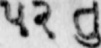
પરંતુ
